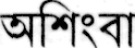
অশিংবা
